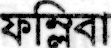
ফম্লিবা
